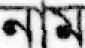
নাম
